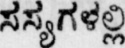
ಸಸ್ಯಗಳಲ್ಲಿ
